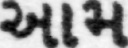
આમ
